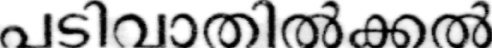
പടിവാതില്‍ക്കല്‍
